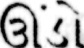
ઊંડો
